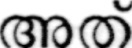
അത്
